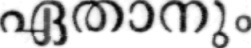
ഏതാനും
